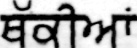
ਥੱਕੀਆਂ
